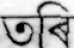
তৰি
